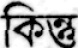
কিন্তু
